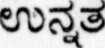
ಉನ್ನತ
